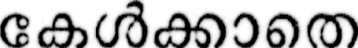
കേള്‍ക്കാതെ
